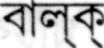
বাল্‌ক্
